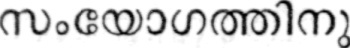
സംയോഗത്തിനു
